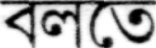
বলতে
